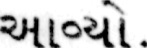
આવ્યો.
